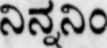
ನಿನ್ನನಿಂ
